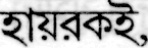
হায়রকই,
